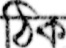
ঠিক
